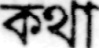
কথা
